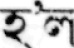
হ'ল
